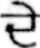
ਦੇ
